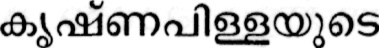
കൃഷ്ണപിള്ളയുടെ
